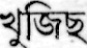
খুজিছ
